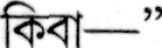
কিবা-"
